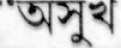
"অসুখ
